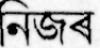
নিজৰ
